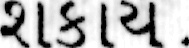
શકાય.
